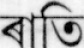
ৰাতি
